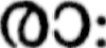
രാ:
